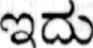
ಇದು
